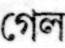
গেল
